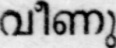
വീണു
